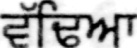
ਵੱਢਿਆਂ
